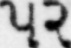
પર
